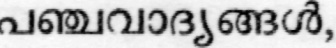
പഞ്ചവാദ്യങ്ങള്‍,
